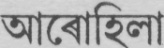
আৰোহিলা
